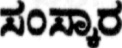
ಸ೦ಸ್ಕಾರ
